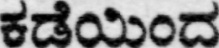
ಕಡೆಯಿ೦ದ
